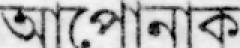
আপোনাক
